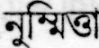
নুম্মিত্তা
